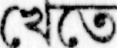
খেতে
